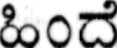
ಹಿಂದೆ
